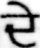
ਦੇ
